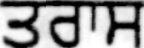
ਤਰਾਸ
